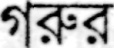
গরুর
